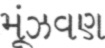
મૂંઝવણ
